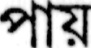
পায়
